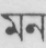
মন
